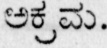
ಅಕ್ರಮ.
